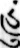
હું
